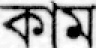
কাম
